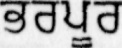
ਭਰਪੂਰ
